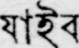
যাইব
